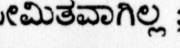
ಸೀಮಿತವಾಗಿಲ್ಲ
